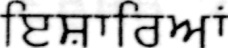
ਇਸ਼ਾਰਿਆਂ
